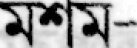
মশম-
